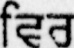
ਵਿਚ
